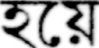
হয়ে
